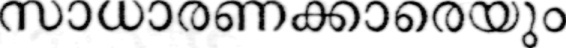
സാധാരണക്കാരെയും
